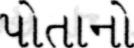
પોતાનો
